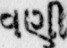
વણી
